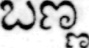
ಬಣ್ಣ
